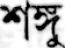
শঙ্গু
